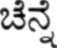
ಚೆನ್ನೆ
